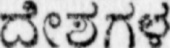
ದೇಶಗಳ
